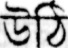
উঠি
